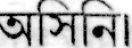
অসিনি।
